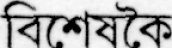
বিশেষকৈ
